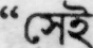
"সেই
